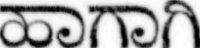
ಹಾಗಾಗಿ
